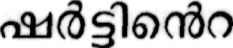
ഷര്‍ട്ടിന്റെ
